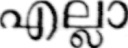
എല്ലാ
